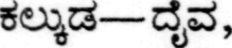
ಕಲ್ಕುಡ-ದೈವ,
